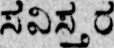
ಸವಿಸ್ತರ
